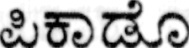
ಪಿಕಾಡೊ
